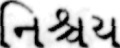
નિશ્ચય
